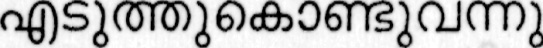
എടുത്തുകൊണ്ടുവന്നു
